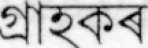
গ্রাহকৰ
